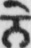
ਨੇ
